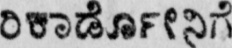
ರಿಕಾರ್ಡೋನಿಗೆ
